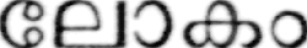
ലോകം
